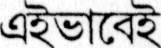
এইভাবেই
